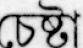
চেষ্টা
